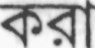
করা
